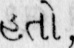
હતો,
